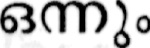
ഒന്നും
